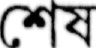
শেষ
